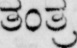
ತಂತ್ರ
